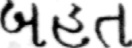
બહત
